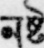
নষ্ট
